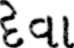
દેવા
